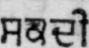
ਸਕਦੀ
